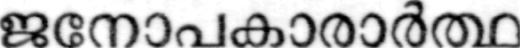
ജനോപകാരാര്‍ത്ഥ
